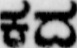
ಕದ
